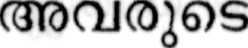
അവരുടെ
